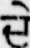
ਦੇ
